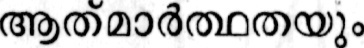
ആത്മാര്‍ത്ഥതയും
